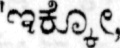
‘ಇಕ್ಕೋ,
